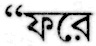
“ফরে
